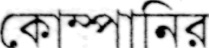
কোম্পানির
